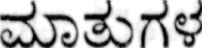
ಮಾತುಗಳ
